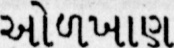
ઓળખાણ
